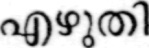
എഴുതി
